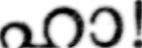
ഹാ!
